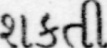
શકતી
